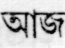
আজ
